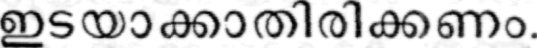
ഇടയാക്കാതിരിക്കണം.
